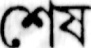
শেষ
